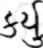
કર્યુ
